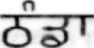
ਠੰਡਾ
